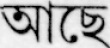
আছে
